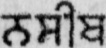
ਨਸੀਬ
